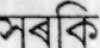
সৰকি
